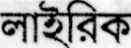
লাইরিক
